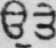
ਉਤੇ
